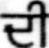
ਦੀ
